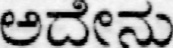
ಅದೇನು
